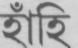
হাঁহি
